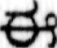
ಈ
